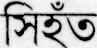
সিহঁত
